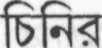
চিনির
